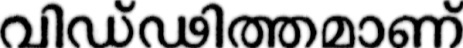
വിഡ്ഢിത്തമാണ്
